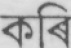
কৰি
